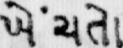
ખેંચતો
